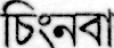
চিংনবা
